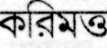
করিমত্ত
